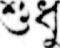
শুধু
